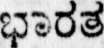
ಭಾರತ
